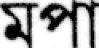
মপা
